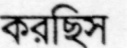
করছিস
